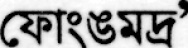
ফোংঙমদ্র’
